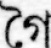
গৈ
